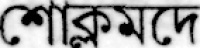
শোক্লমদে
